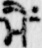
ਮੈਂ
